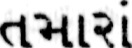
તમારાં
